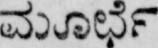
ಮೂರ್ಛೆ
